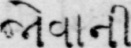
જોવાની
